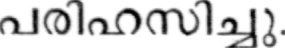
പരിഹസിച്ചു.
